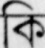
কি
